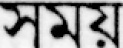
সময়
